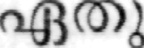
ഏതു
